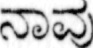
ನಾವು
